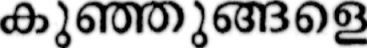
കുഞ്ഞുങ്ങളെ
